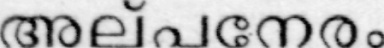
അല്പനേരം
